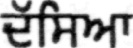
ਦੱਸਿਆ
